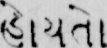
હોયતો
